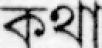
কথা
